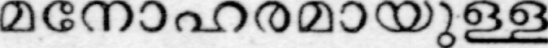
മനോഹരമായുള്ള
